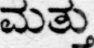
ಮತ್ತು
